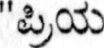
“ಪ್ರಿಯ
